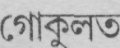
গোকুলত
